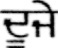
ਦੂਜੇ
